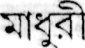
মাধুরী
